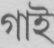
গাই
